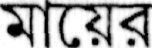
মায়ের
